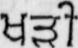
ਖੜੀ
